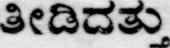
ತೀಡಿದತ್ತು
